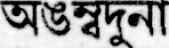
অঙম্বদুনা
